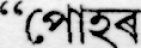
"পোহৰ
